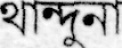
থান্দুনা
